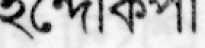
হন্দোকপা
